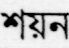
শয়ন
